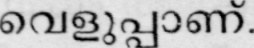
വെളുപ്പാണ്.
